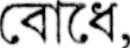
বোধে,
